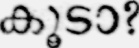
കൂടാ?
